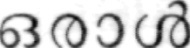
ഒരാള്‍
